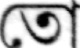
তো
